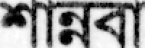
শান্নবা
